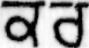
ਕਰ
